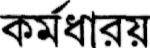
কর্মধারয়
